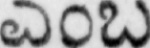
ಎಂಬ
